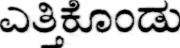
ಎತ್ತಿಕೊಂಡು
